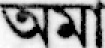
অমা
